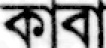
কাবা
